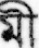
মী
